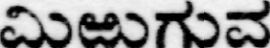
ಮಿಱುಗುವ
